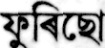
ফুৰিছো
